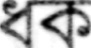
ধক
